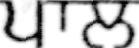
ਪਾਲ
